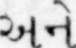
અને
